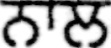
ਨਾਲ
